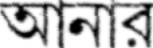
আনার
